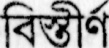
বিস্তীর্ণ
